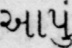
આપું
